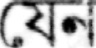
যেন
